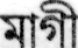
মাগী
